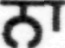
ਨਾ
